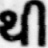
થી
